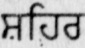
ਸ਼ਹਿਰ
